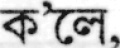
ক'লে,
